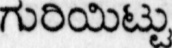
ಗುರಿಯಿಟ್ಟು
